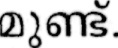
മുണ്ട്.
